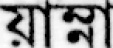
য়াম্না
